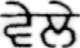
ਵੇਲੇ
